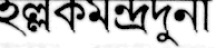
হল্লকমন্দ্রদুনা
